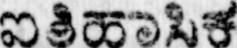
ಐತಿಹಾಸಿಕ
